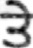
ਤੇ
